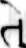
તે
